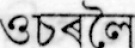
ওচৰলৈ
